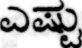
ಎಷ್ಟು
